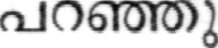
പറഞ്ഞു
